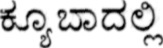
ಕ್ಯೂಬಾದಲ್ಲಿ
